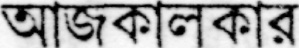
আজকালকার
